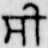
ਸੀ
